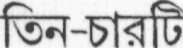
তিন-চারটি
